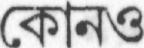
কোনও
